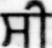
ਸੀ
